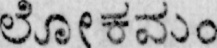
ಲೋಕಮಂ
